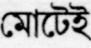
মোটেই
